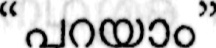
"പറയാം"
